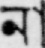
না
